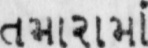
તમારામાં
